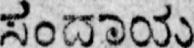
ಸಂದಾಯ
